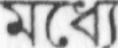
মধ্যে
